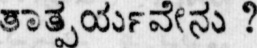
ತಾತ್ಪರ್ಯವೇನು?
